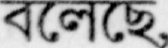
বলেছে,
